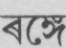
ৰঙ্গে
